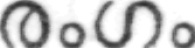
രംഗം
